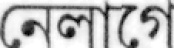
নেলাগে
